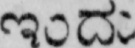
ಇಂದು
